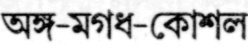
অঙ্গ-মগধ-কোশল
